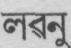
লৱনু
